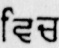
ਵਿਚ
